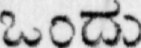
ಒಂದು
